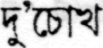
দু’চোখ
